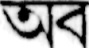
অব
